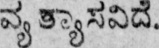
ವ್ಯತ್ಯಾಸವಿದೆ.
